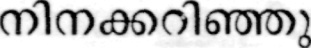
നിനക്കറിഞ്ഞു
